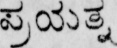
ಪ್ರಯತ್ನ
